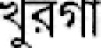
খুরগা
